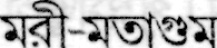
মরী-মতাগুম
